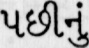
પછીનું
